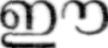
ഈ
